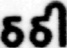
ઠઠી
